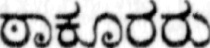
ಠಾಕೂರರು
